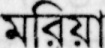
মরিয়া
